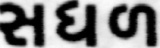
સધળ
